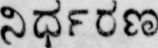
ರ್ಧರಣ
